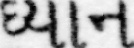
ધ્યાન
